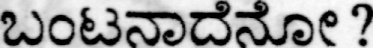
ಬಂಟನಾದೆನೋ?
